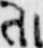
તો
